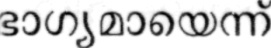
ഭാഗ്യമായെന്ന്
